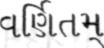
વર્ણિતમ્
